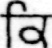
ਕਿ
